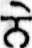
ਨੇ
